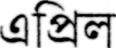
এপ্রিল
